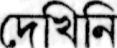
দেখিনি
